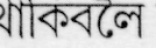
থাকিবলৈ
